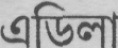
এড়িলা
